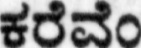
ಕರೆವೆಂ
